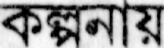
কল্পনায়
